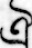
ঐ
